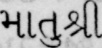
માતુશ્રી
